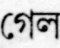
গেল
